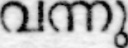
വന്നു
